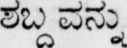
ಶಬ್ದವನ್ನು
